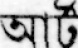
আর্ট
